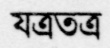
যত্রতত্র
